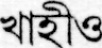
খাহীও
